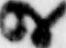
જ
